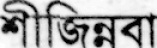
শীজিন্নবা
